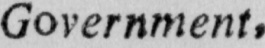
Government,
